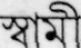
স্বামী
